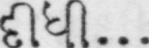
દીધી...
